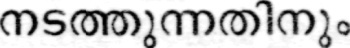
നടത്തുന്നതിനും
